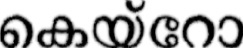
കെയ്റോ
